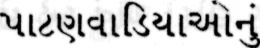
પાટણવાડિયાઓનું
